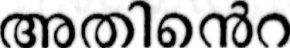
അതിന്റെ
